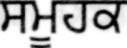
ਸਮੂਹਕ
